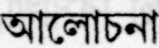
আলোচনা
